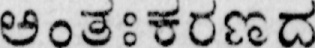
ಅಂತಃಕರಣದ
